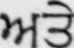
ਅਤੇ
